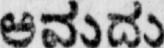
ಆಮದು
